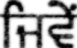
ਜਿਵੇਂ
